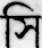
সি
